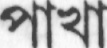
পাখা
